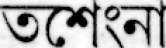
তশেংনা
